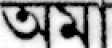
অমা
